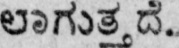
ಲಾಗುತ್ತದೆ.
